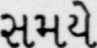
સમયે
